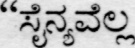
“ಸೈನ್ಯವೆಲ್ಲ
